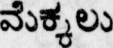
ಮೆಕ್ಕಲು
